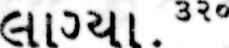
લાગ્યા.૩૨૦
